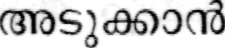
അടുക്കാന്‍
